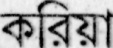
করিয়া
